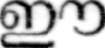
ഈ
